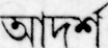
আদর্শ
